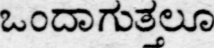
ಒಂದಾಗುತ್ತಲೂ
